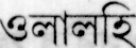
ওলালহি
